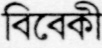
বিবেকী
